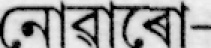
নোৱাৰো-
